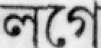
লগে
